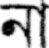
না
